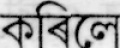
কৰিলে
